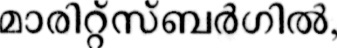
മാരിറ്റ്സ്ബര്‍ഗില്‍,
